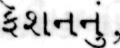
ફૅશનનું,
